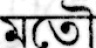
মতৌ
